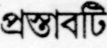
প্রস্তাবটি
